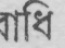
বাধি
